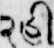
રહી
